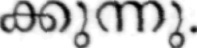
ക്കുന്നു.
